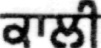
ਕਾਲੀ
